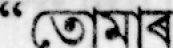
"তোমাৰ
